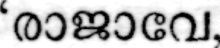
‘രാജാവേ,
